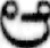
ಆ
